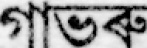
গাভৰু
